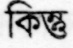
কিন্তু
